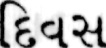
દિવસ
